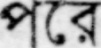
পরে
